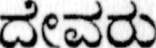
ದೇವರು
